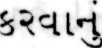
કરવાનું
